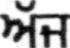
ਅੱਜ
